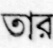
তার
